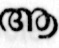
ആ
